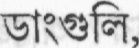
ডাংগুলি,
